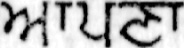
ਆਪਣਾ
